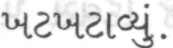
ખટખટાવ્યું.
